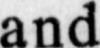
and
